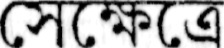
সেক্ষেত্রে
